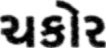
ચકોર
